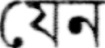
যেন
